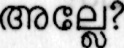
അല്ലേ?
